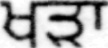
ਖੜਾ
